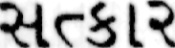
સત્કાર
